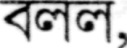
বলল,
